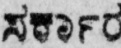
ಸರ್ಕಾರ
